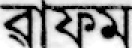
ৱাফম
